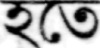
হতে
